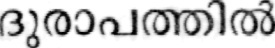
ദുരാപത്തില്‍
